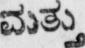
ಮತ್ತು
